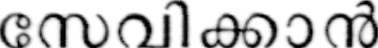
സേവിക്കാന്‍
